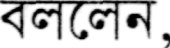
বললেন,
